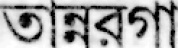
তান্নরগা
